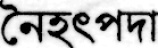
নৈহৎপদা
